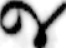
જ
